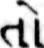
તો
